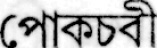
পোকচবী
